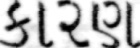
કારણ
